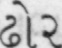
ઢોર
